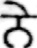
ਨੇ
